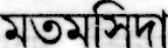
মতমসিদা
